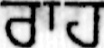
ਰਾਹ
